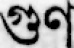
গুণ
